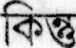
কিন্তু
